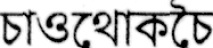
চাওথোকচৈ
